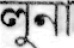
লুনা
